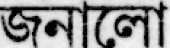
জনালো
